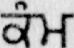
ਕੰਮ
